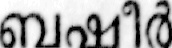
ബഷീര്‍
